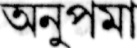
অনুপমা
